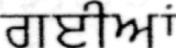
ਗਈਆਂ
